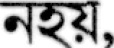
নহয়,
